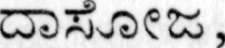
ದಾಸೋಜ,
